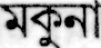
মকুনা
